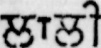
ਲਾਲੀ
